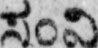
ಸಂವಿ
